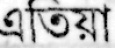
এতিয়া
